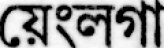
য়েংলগা
